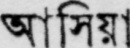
আসিয়া
